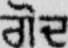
ਗੋਦ
